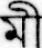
মী
